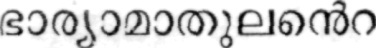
ഭാര്യാമാതുലന്റെ
